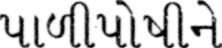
પાળીપોષીને
